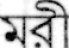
মরী
